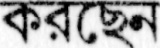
করছেন
